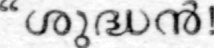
"ശുദ്ധന്‍!
